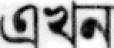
এখন
